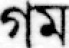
গম
